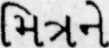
મિત્રને
